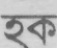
হক
